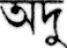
অদু
